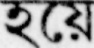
হয়ে
